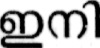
ഇനി
